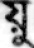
য়ু
